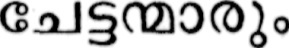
ചേട്ടന്മാരും
